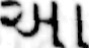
આ
